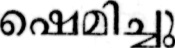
ഷെമിച്ചു
